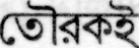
তৌরকই
